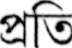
প্রতি
